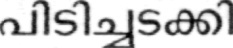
പിടിച്ചടക്കി
